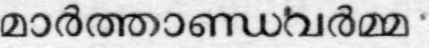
മാര്‍ത്താണ്ഡവര്‍മ്മ
